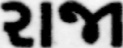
રાજા
